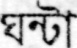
ঘন্টা
